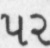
પર
